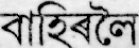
বাহিৰলৈ
